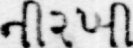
નીરખી
